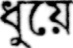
ধুয়ে
